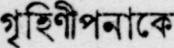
গৃহিণীপনাকে
